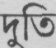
দুতি
